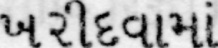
ખરીદવામાં
